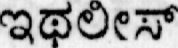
ಇಥಲೀಸ್
